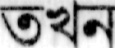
তখন
